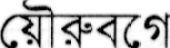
য়ৌরুবগে
